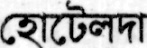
হোটেলদা
